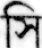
সি
